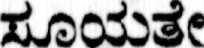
ಸೂಯತೇ
